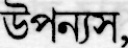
উপন্যাস,
